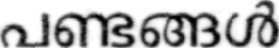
പണ്ടങ്ങള്‍
